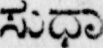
ಸುಧಾ
